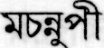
মচন্নুপী
